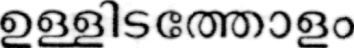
ഉള്ളിടത്തോളം
